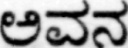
ಅವನ
